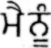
ਮੈਨੂੰ
